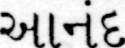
આનંદ
